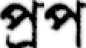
প্রপ
